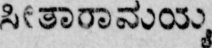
ಸೀತಾರಾಮಯ್ಯ
